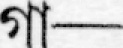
গা-
